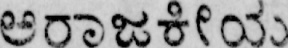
ಅರಾಜಕೀಯ
